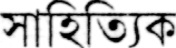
সাহিত্যিক
